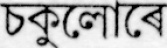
চকুলোৰে
